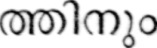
ത്തിനും
